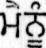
ਮੈਨੂੰ
